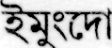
ইমুংদো
